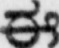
ಈ
